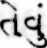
તેવું
